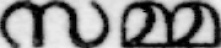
സമ്മ
